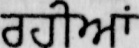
ਰਹੀਆਂ
